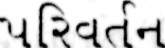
પરિવર્તન
